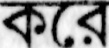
করে
